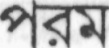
পরম
